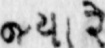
જ્યારે
